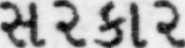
સરકાર
